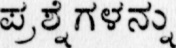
ಪ್ರಶ್ನೆಗಳನ್ನು
